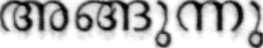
അങ്ങുന്നു
